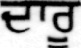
ਦਾਰੂ
